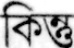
কিন্তু
